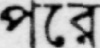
পরে
